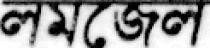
লমজেল
